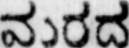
ಮರದ
